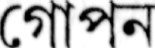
গোপন
